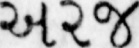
અરજ
